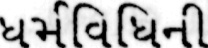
ધર્મવિધિની
